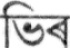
ভিৰ
